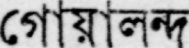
গোয়ালন্দ
